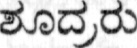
ಶೂದ್ರರು
